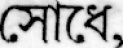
সোধে,
